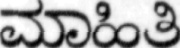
ಮಾಹಿತಿ
